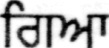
ਗਿਆ
